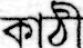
কাঠী
